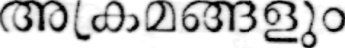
അക്രമങ്ങളും
